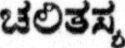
ಚಲಿತಸ್ಯ
